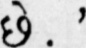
છે.'
